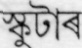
স্কুটাৰ
